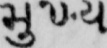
મુખ્ય
